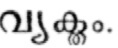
വ്യക്തം.
